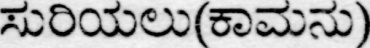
ಸುರಿಯಲು(ಕಾಮನು)
